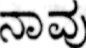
ನಾವು
